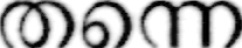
തന്നെ
